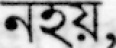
নহয়,
